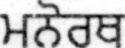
ਮਨੋਰਥ
